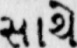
સાથે
